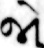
જો
